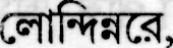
লোন্দিন্নরে,
